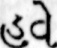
હવે
